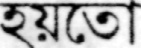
হয়তো
